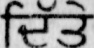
ਦਿੱਤੇ
